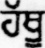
ਹੱਥੂ
